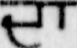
ਦਾ
